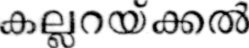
കല്ലറയ്ക്കല്‍
